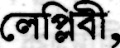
লেপ্লিবী,
